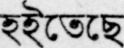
হইতেছে
